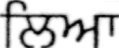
ਲਿਆ
